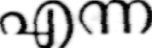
എന്ന
